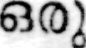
ഒരു
